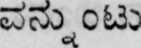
ವನ್ನುಂಟು
